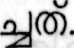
ച്ചത്.
